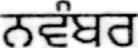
ਨਵੰਬਰ
